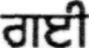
ਗਈ
